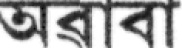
অৱাবা
